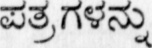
ಪತ್ರಗಳನ್ನು
